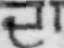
ਦਾ
